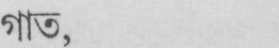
গাত,
